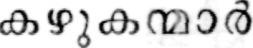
കഴുകന്മാര്‍
